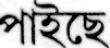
পাইছে
